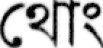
থোং
